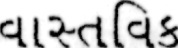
વાસ્તવિક
